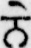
ਨੇ
